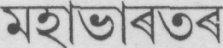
মহাভাৰতৰ
